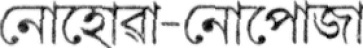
নোহোৱা-নোপোজা
